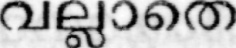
വല്ലാതെ
